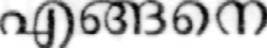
എങ്ങനെ
